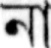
না
